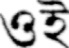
ওই
